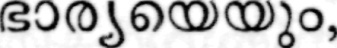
ഭാര്യയെയും,
